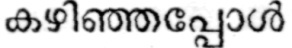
കഴിഞ്ഞപ്പോള്‍
